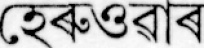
হেৰুওৱাৰ
